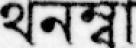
থনম্বা
